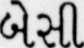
બેસી
